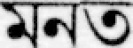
মনত
